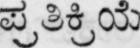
ಪ್ರತಿಕ್ರಿಯೆ
